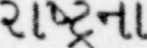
રાષ્ટ્રના
